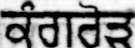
ਕੰਗਰੋੜ
